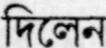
দিলেন
